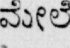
ಮೇಲೆ
